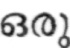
ഒരു
